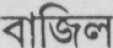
বাজিল
